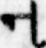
ન
